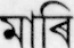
মাৰি
